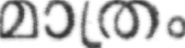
മാത്രം
